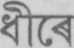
ধীৰে
